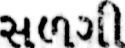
સળગી
